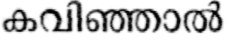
കവിഞ്ഞാല്‍
